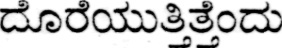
ದೊರೆಯುತ್ತಿತ್ತೆಂದು
